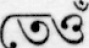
তেওঁ
